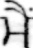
ਮੈਂ
